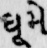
ધૂમે
